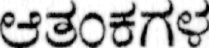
ಆತಂಕಗಳ
